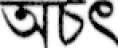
অচৎ
